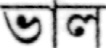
ভাল
